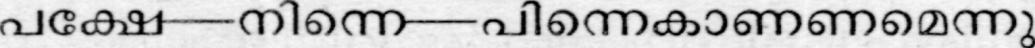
പക്ഷേ-നിന്നെ-പിന്നെകാണണമെന്നു
